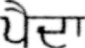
ਪੈਦਾ
